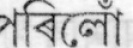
পৰিলোঁ
